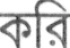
করি
